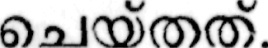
ചെയ്തത്.
